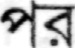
পর
